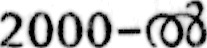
2000-ല്‍
